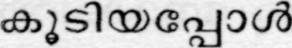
കൂടിയപ്പോള്‍
